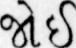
જોઈ
